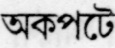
অকপটে
